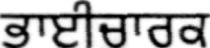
ਭਾਈਚਾਰਕ
